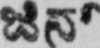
ಜಿನ್
